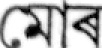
মোৰ
